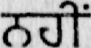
ਨਹੀਂ
